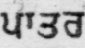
ਪਾਤਰ
